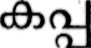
കപ്പ
